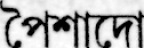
পৈশাদো
